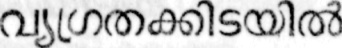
വ്യഗ്രതക്കിടയില്‍
